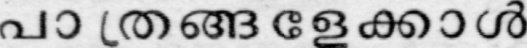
പാത്രങ്ങളേക്കാള്‍
